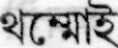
থম্মোই
